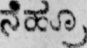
ನೆಹ್ರೂ
